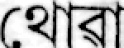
থোৱা
